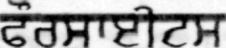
ਫੌਰਸਾਈਟਸ
